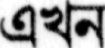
এখন
